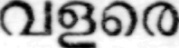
വളരെ
